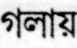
গলায়
